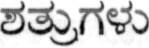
ಶತ್ರುಗಳು
